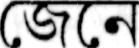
জেনে
